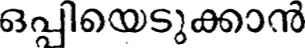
ഒപ്പിയെടുക്കാന്‍
